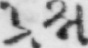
પ્રશ્ન
